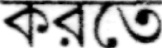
করতে
